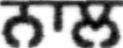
ਨਾਲ
